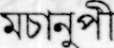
মচানুপী
